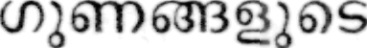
ഗുണങ്ങളുടെ
